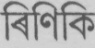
ৰিণিকি
